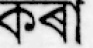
কৰা
